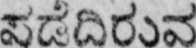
ಪಡೆದಿರುವ
